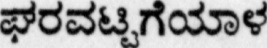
ಘರವಟ್ಟಿಗೆಯಾಳ
